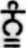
ਨੂੰ
